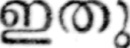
ഇതു
